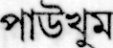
পাউখুম
